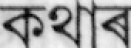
কথাৰ
